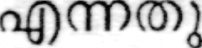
എന്നതു
